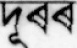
দূৰৰ
